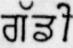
ਗੱਡੀ
